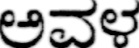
ಅವಳ
